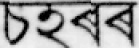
চহৰৰ
